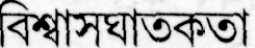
বিশ্বাসঘাতকতা
